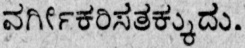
ವರ್ಗೀಕರಸತಕ್ಕುದು.
